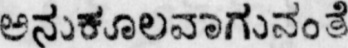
ಅನುಕೂಲವಾಗುವಂತೆ
